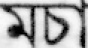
মচা
